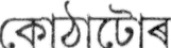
কোঠাটোৰ
